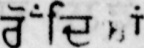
ਰੋਂਦਿਆਂ
